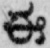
ಈ
